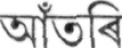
আঁতৰি
